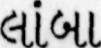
લાંબા
